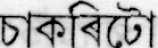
চাকৰিটো
